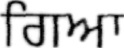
ਗਿਆ
